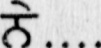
ਨੇ....
